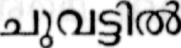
ചുവട്ടില്‍
